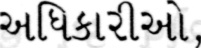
અધિકારીઓ,
